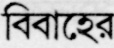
বিবাহের
